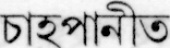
চাহপানীত
